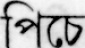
পিচে
